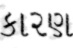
કારણ
